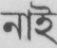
নাই
